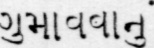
ગુમાવવાનું
